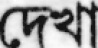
দেখা
